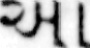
આ
